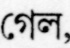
গেল,
